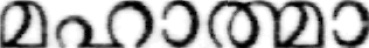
മഹാത്മാ
